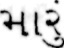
મારું
